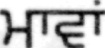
ਮਾਵਾਂ
